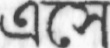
এসে
